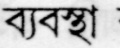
ব্যবস্থা
